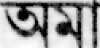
অমা
